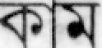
কাম
